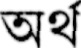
অর্থ
